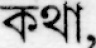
কথা,
